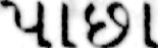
પાછા
